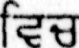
ਵਿਚ
